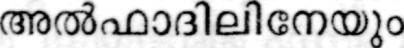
അല്‍ഫാദിലിനേയും
